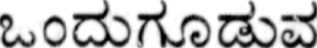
ಒಂದುಗೂಡುವ
